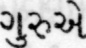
ગુરુએ
